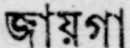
জায়গা
